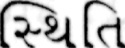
સ્થિતિ
